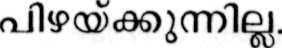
പിഴയ്ക്കുന്നില്ല.
